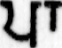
ਪਾ
